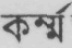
কৰ্ম্ম
